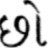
છો
